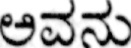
ಅವನು
